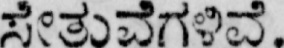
ಸೇತುವೆಗಳಿವೆ.
